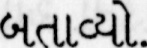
બતાવ્યો.
